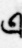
এ
